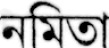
নমিতা
